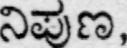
ನಿಪುಣ,
